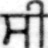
ਸੀ
